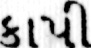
કાપી
